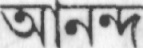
আনন্দ
